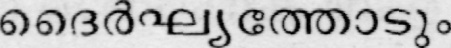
ദൈര്‍ഘ്യത്തോടും
